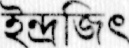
ইন্দ্রজিৎ
